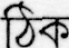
ঠিক
